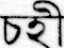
চহী
